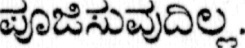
ಪೂಜಿಸುವುದಿಲ್ಲ.
